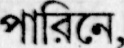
পারিনে,
